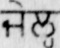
ਜੇਲ੍ਹ
